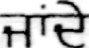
ਜਾਂਦੇ
